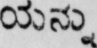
ಯನ್ನು
